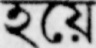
হয়ে
